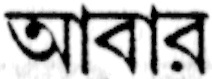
আবার
